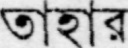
তাহার
